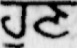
ਹੁਣ
